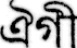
ঐগী
